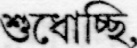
শুধোচ্ছি,
